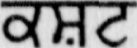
ਕਸ਼ਟ
